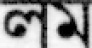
লম
